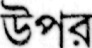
উপর
